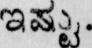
ಇಷ್ಟು.
